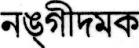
নঙগীদমক
